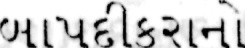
બાપદીકરાનો
